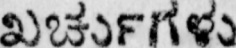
ಖರ್ಚುಗಳು
